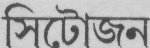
সিটোজন
